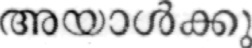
അയാള്‍ക്കു
